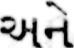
અને
